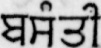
ਬਸੰਤੀ
